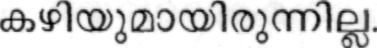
കഴിയുമായിരുന്നില്ല.
